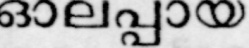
ഓലപ്പായ
